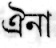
ঐনা
